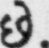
છે.
